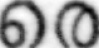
രെ
